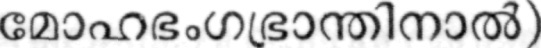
മോഹഭംഗഭ്രാന്തിനാല്‍)
